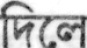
দিলে
